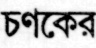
চণকের
